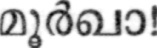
മൂര്‍ഖാ!
